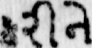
કરીને
